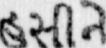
હસીને
